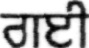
ਗਈ
